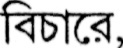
বিচারে,
